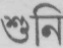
শুনি
